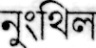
নুংথিল
